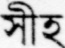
সীহ
